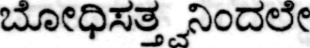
ಬೋಧಿಸತ್ತ್ವನಿಂದಲೇ
